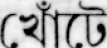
খোঁটে
